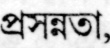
প্রসন্নতা,
